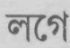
লগে
